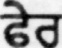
ਫੇਰ
